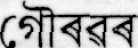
গৌৰৱৰ
